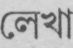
লেখা
